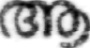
ആ
